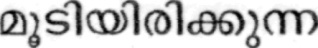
മൂടിയിരിക്കുന്ന
